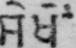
ਸੇਖੋਂ
